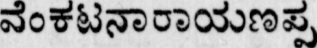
ವೆಂಕಟನಾರಾಯಣಪ್ಪ
